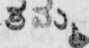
ತಮ್ಮ
